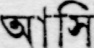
আসি
